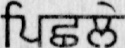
ਪਿਛਲੇ
